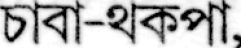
চাবা-থকপা,
